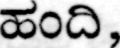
ಹಂದಿ,
